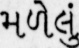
મળેલું
